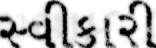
સ્વીકારી
